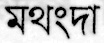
মথংদা
